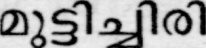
മുട്ടിച്ചിരി
